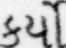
કર્યો
